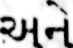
અને
